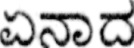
ಏನಾದ
